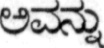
ಅವನ್ನು
